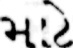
માટે
